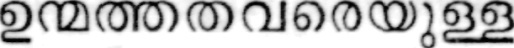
ഉന്മത്തതവരെയുള്ള
